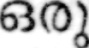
ഒരു
